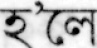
হ'লে
